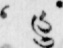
'હું
